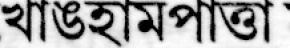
খোঙহামপাত্তা
